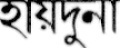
হায়দুনা
